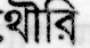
থৌরি
